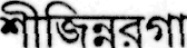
শীজিন্নরগা
